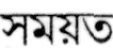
সময়ত
